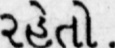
રહેતો.
